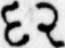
દર
